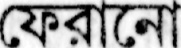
ফেরানো
